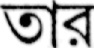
তার
